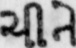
ચીને
